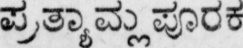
ಪ್ರತ್ಯಾಮ್ಲಪೂರಕ
